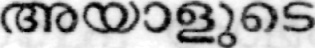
അയാളുടെ
